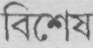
বিশেষ
